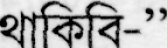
থাকিবি-"
